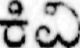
ಕಿವಿ
